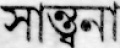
সান্ত্বনা
